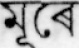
মূৰে
